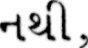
નથી,
